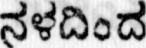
ನಳದಿಂದ
